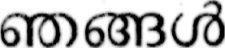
ഞങ്ങള്‍
